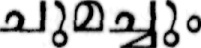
ചുമച്ചും
